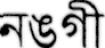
নঙগী
